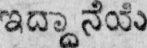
ಇದ್ದಾನೆಯೆ
